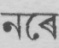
নৰে
